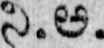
ನಿ.ಅ.
